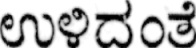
ಉಳಿದಂತೆ
